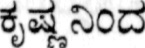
ಕೃಷ್ಣನಿಂದ
